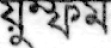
য়ুম্ফম
